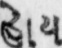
હોય
